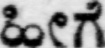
ಹೀಗೆ
